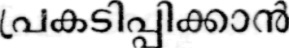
പ്രകടിപ്പിക്കാന്‍
